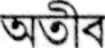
অতীব
